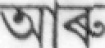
আৰু
